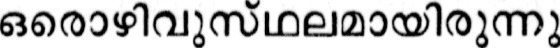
ഒരൊഴിവുസ്ഥലമായിരുന്നു
